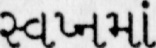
સ્વપ્નમાં
